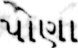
પોણા
